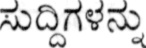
ಸುದ್ದಿಗಳನ್ನು
